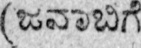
(ಜವಾಬಿಗೆ
